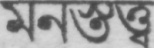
মনস্তত্ত্ব
